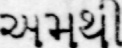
અમથી
